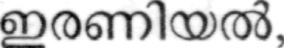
ഇരണിയല്‍,
